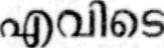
എവിടെ
